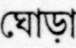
ঘোড়া
